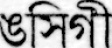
ঙসিগী
